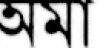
অমা
